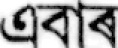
এবাৰ
